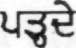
ਪੜ੍ਹਦੇ
